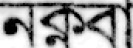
নক্নবা
